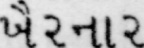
ખૈરનાર
